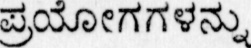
ಪ್ರಯೋಗಗಳನ್ನು
